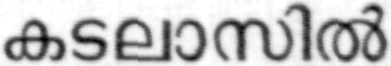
കടലാസില്‍
